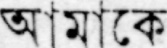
আমাকে
